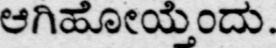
ಆಗಿಹೋಯ್ತೆಂದು.
